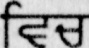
ਵਿਚ
